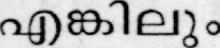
എങ്കിലും
